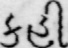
કહી
